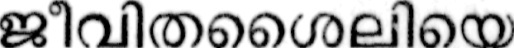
ജീവിതശൈലിയെ
